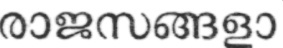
രാജസങ്ങളാ
